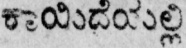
ಕಾಯಿದೆಯಲ್ಲಿ
